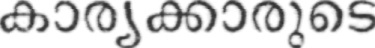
കാര്യക്കാരുടെ
